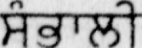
ਸੰਭਾਲੀ
